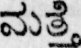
ಮತ್ತೆ
